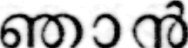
ഞാന്‍
